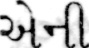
એની
